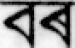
বৰ
